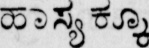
ಹಾಸ್ಯಕ್ಕೂ
